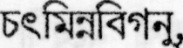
চৎমিন্নবিগনু,
